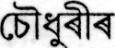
চৌধুৰীৰ
